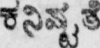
ಕನಿಷ್ಟತೆ
